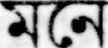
মনে
